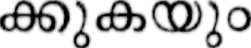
ക്കുകയും
